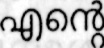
എന്റെ
